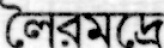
লৈরমদ্রে
